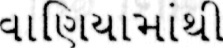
વાણિયામાંથી
